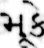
મૂકે
